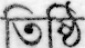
তিষ্ঠি
